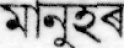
মানুহৰ
